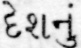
દેશનું
